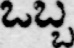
ಒಬ್ಬ
